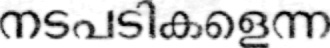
നടപടികളെന്ന
